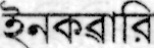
ইনকৱারি
